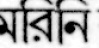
মরিনি
